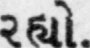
રહ્યો.
